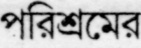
পরিশ্রমের
